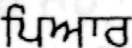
ਪਿਆਰ
